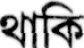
থাকি
